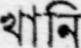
খানি
